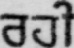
ਰਹੀ
